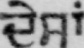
ਦੇਸਾਂ
